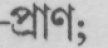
প্ৰাণ;
